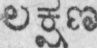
ಲಕ್ಷಣ
